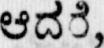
ಆದರೆ,
